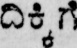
ದಿಕ್ಕಿಗೆ
